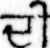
ਦੀ
